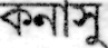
কনাসু
